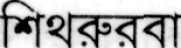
শিথরুরবা
